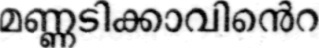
മണ്ണടിക്കാവിന്റെ
